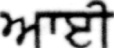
ਆਈ
